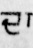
ਦਾ
